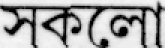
সকলো
